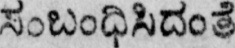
ಸಂಬಂಧಿಸಿದಂತೆ
